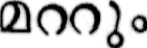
മററും
